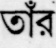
তাঁর
